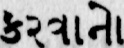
કરવાનો
